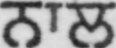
ਨਾਲ
